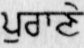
ਪੁਰਾਣੇ
